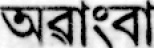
অৱাংবা
